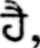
ਹੈ,
